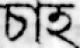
চাহ
